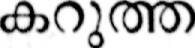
കറുത്ത
